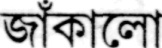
জাঁকালো
